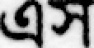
এস
